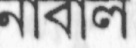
নাবাল
